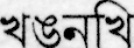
খঙনখি
